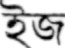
ইজ
